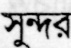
সুন্দর
